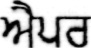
ਐਪਰ
